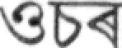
ওচৰ
